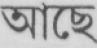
আছে
